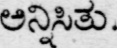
ಅನ್ನಿಸಿತು.
